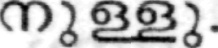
നുള്ളു.
